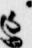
હું
